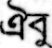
ঐবু
